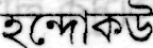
হন্দোকউ
